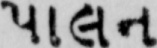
પાલન
